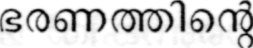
ഭരണത്തിന്റെ
